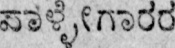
ಪಾಳ್ಳೇಗಾರರ
